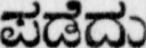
ಪಡೆದು
